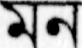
মন
